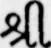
શ્રી
